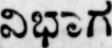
ವಿಭಾಗ
